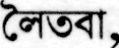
লৈতবা,
